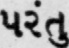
પરંતુ
